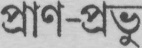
প্ৰাণ-প্ৰভু
